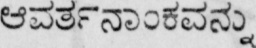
ಆವರ್ತನಾಂಕವನ್ನು
